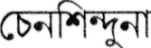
চেনশিন্দুনা
